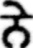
ਨੇ
